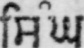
ਸਿੰਘ
